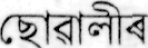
ছোৱালীৰ
